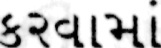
કરવામાં
